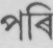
পৰি
